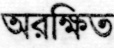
অরক্ষিত
